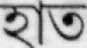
হাত
